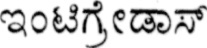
ಇಂಟಿಗ್ರೇಡಾಸ್
